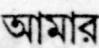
আমার
